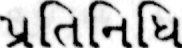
પ્રતિનિધિ
